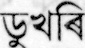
ডুখৰি
